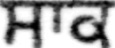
ਸਾਕ
